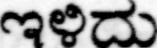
ಇಳಿದು
